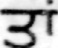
ਤਾਂ
